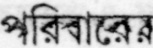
পরিবারের
